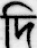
দি
